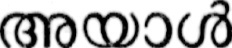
അയാള്‍
